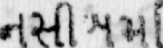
નસીબમાં
